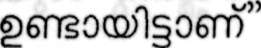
ഉണ്ടായിട്ടാണ്"
